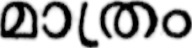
മാത്രം
